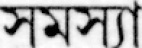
সমস্যা
